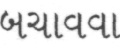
બચાવવા
